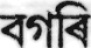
বগৰি
